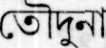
তৌদুনা
